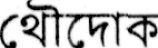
থৌদোক
